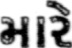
મારે
